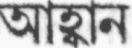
আহ্বান
